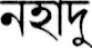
নহাদু
